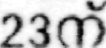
23ന്
